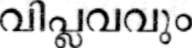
വിപ്ലവവും
